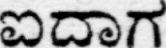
ಐದಾಗ
